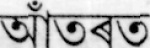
আঁতৰত
